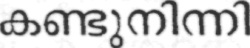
കണ്ടുനിന്നി
